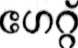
ഗേറ്റ്
